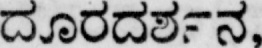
ದೂರದರ್ಶನ,
